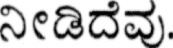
ನೀಡಿದೆವು.
